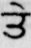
ਤੇ
